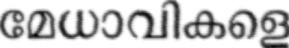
മേധാവികളെ
